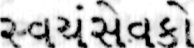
સ્વયંસેવકો
